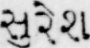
સુરેશ
